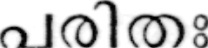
പരിതഃ
